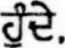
ਹੁੰਦੇ,
